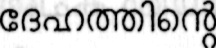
ദേഹത്തിന്റെ
